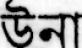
উনা
